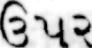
ઉપર
